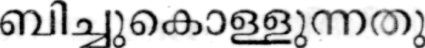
ബിച്ചുകൊള്ളുന്നതു
